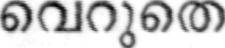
വെറുതെ
